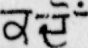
ਕਦੋਂ
